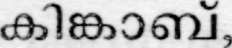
കിങ്കാബ്,
